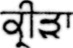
ਕ੍ਰੀੜਾ
